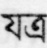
যত্র
